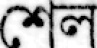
শেল
